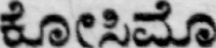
ಕೋಸಿಮೊ
